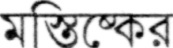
মস্তিষ্কের
